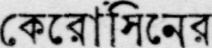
কেরোসিনের
